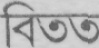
বিতত
